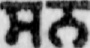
ਸਨ
